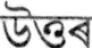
উত্তৰ
